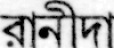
রানীদা
